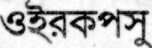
ওইরকপসু
